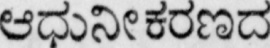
ಆಧುನೀಕರಣದ
